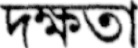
দক্ষতা
